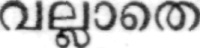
വല്ലാതെ
